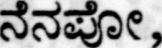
ನೆನಪೋ,
